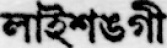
লাইশঙগী
